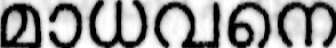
മാധവനെ
